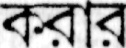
করার
